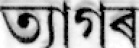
ত্যাগৰ
